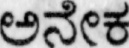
ಅನೇಕ
